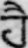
ਹੈ
